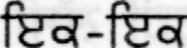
ਇਕ-ਇਕ
